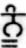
ਨੂੰ
